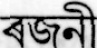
ৰজনী
